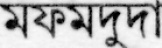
মফমদুদা
